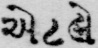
એટલે
